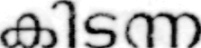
കിടന്ന
